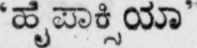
‘ಹೈಪಾಕ್ಸಿಯಾ’
